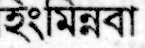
হিংমিন্নবা
